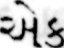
એક
